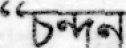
"চন্দন
